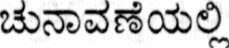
ಚುನಾವಣೆಯಲ್ಲಿ
